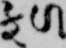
ફળ
